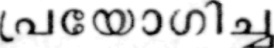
പ്രയോഗിച്ച
